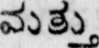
ಮತ್ತು
